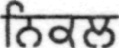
ਨਿਕਲ
